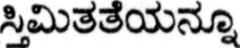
ಸ್ತಿಮಿತತೆಯನ್ನೂ
